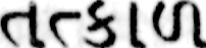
તત્કાળ
